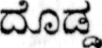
ದೊಡ್ಡ
